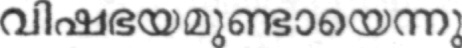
വിഷഭയമുണ്ടായെന്നു
